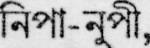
নিপা-নুপী,
